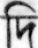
দি
